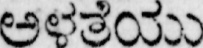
ಅಳತೆಯು
